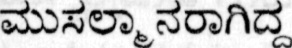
ಮುಸಲ್ಮಾನರಾಗಿದ್ದ
